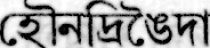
হৌনদ্রিঙৈদা
